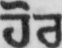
ਹੋਰ
